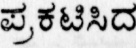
ಪ್ರಕಟಿಸಿದ
